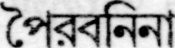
পৈরবনিনা
